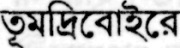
তূমদ্রিবোইরে
